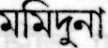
মমিদুনা
